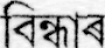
বিন্ধাৰ
